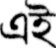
এই
